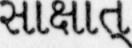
સાક્ષાત્
